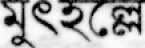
মুৎহল্লে
